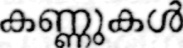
കണ്ണുകള്‍
